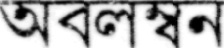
অবলম্বন
